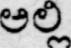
ಅಲ್ಲಿ
